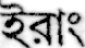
ইরাং
